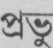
প্ৰভু
